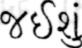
જઈશું
